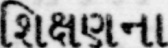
શિક્ષણના
